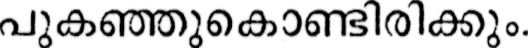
പുകഞ്ഞുകൊണ്ടിരിക്കും.
